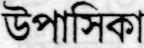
উপাসিকা
